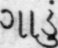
ગાડું
